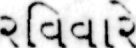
રવિવારે
